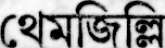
থেমজিল্লি
